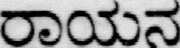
ರಾಯನ
